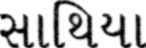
સાથિયા
